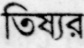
তিষ্যর
